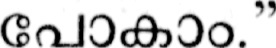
പോകാം.”
